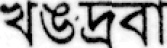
খঙদ্রবা
